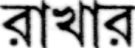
রাখার
